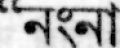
“নংনা
